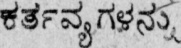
ಕರ್ತವ್ಯಗಳನ್ನು
